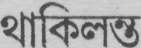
থাকিলন্ত
